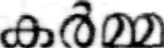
കര്‍മ്മ
